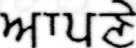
ਆਪਣੇ
